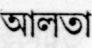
আলতা
